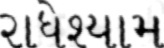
રાધેશ્યામ
